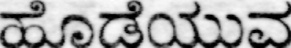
ಹೊಡೆಯುವ
